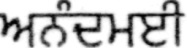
ਅਨੰਦਮਈ
